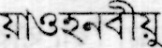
য়াওহনবীয়ু
